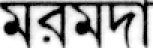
মরমদা
